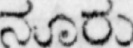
ನೂರು
